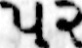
પર
